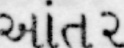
આંતર
